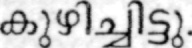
കുഴിച്ചിട്ടു.
